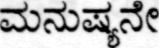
ಮನುಷ್ಯನೇ
